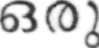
ഒരു
